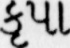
કૃપા
